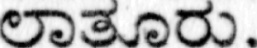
ಲಾತೂರು.
